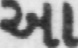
આ
